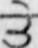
ਤੇ
